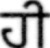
ਹੀ
